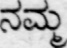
ನಮ್ಮ
